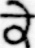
ਕੇ
